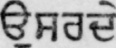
ਉਸਰਦੇ
